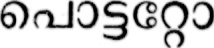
പൊട്ടറ്റോ
